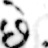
છે.
